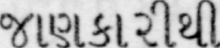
જાણકારીથી
